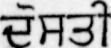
ਦੋਸਤੀ
